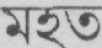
মহত
